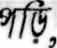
পড়ি,
